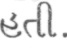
હતી.
